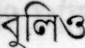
বুলিও
